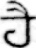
ਹੈ
